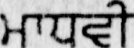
ਮਾਧਵੀ
